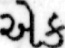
એક
